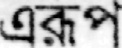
এরূপ
